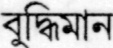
বুদ্ধিমান
